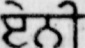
ਏਨੀ
